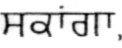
ਸਕਾਂਗਾ,
